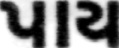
પાય
